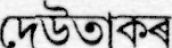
দেউতাকৰ
